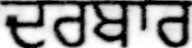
ਦਰਬਾਰ
